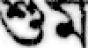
শুম
